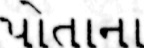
પોતાના
